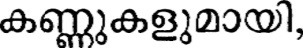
കണ്ണുകളുമായി,
